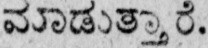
ಮಾಡುತ್ತಾರೆ.
